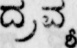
ದ್ರವ್ಯ
